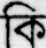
কি
